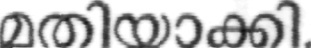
മതിയാക്കി.
